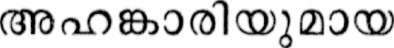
അഹങ്കാരിയുമായ
